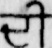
ਦੀ
